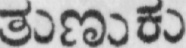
ತುಣುಕು
